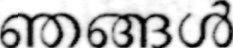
ഞങ്ങള്‍
